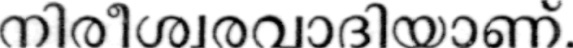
നിരീശ്വരവാദിയാണ്.
